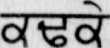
ਕਢਕੇ
